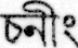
চনীং
